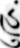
હું
